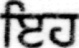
ਇਹ
